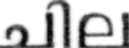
ചില
